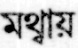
মথ্বায়
